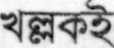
খল্লকই
